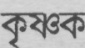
কৃষ্ণক
